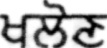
ਖਲੋਣ
